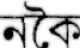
নকৈ
